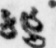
કહું
